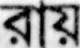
রায়
